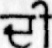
ਦੀ
